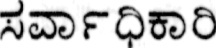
ಸರ್ವಾಧಿಕಾರಿ
